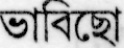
ভাবিছো
